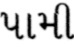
પામી
